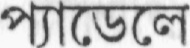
প্যাডেলে
